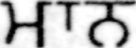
ਮਾਨ
